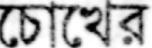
চোখের
